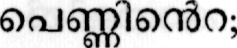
പെണ്ണിന്റെ;
